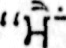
''ਮੈਂ
